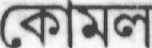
কোমল
